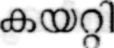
കയറ്റി
